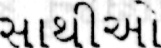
સાથીઓ
